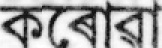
কৰোৱা
